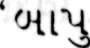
'બાપુ
